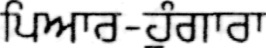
ਪਿਆਰ-ਹੁੰਗਾਰਾ
